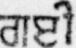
ਗਈ
